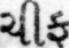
ચીફ
